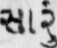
સારું
